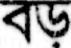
বড়
